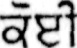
ਕੋਈ
